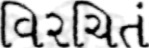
વિરચિતં
